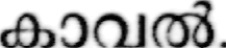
കാവല്‍.
